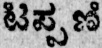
ಟಿಪ್ಪಣಿ
